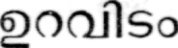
ഉറവിടം
